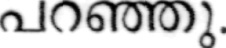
പറഞ്ഞു.
